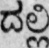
ದಲ್ಲಿ
